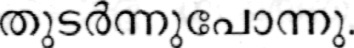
തുടര്‍ന്നുപോന്നു.
